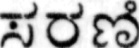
ಸರಣಿ
